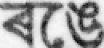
ৰঙে
